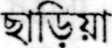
ছাড়িয়া
